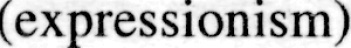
(expressionism)
